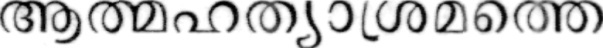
ആത്മഹത്യാശ്രമത്തെ
